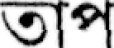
তাপ
